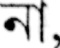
না,
